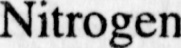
Nitrogen
